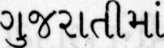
ગુજરાતીમાં
